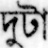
দুটা
